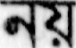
নয়
